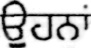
ਉਹਨਾਂ
